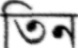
তিন
